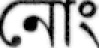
নোং
